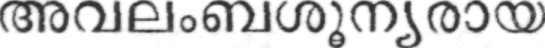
അവലംബശൂന്യരായ
